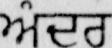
ਅੰਦਰ
